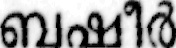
ബഷീര്‍
